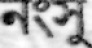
নংসু
